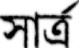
সার্ত্র
